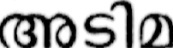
അടിമ
